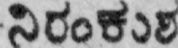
ನಿರಂಕುಶ
